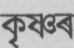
কৃষ্ণৰ
